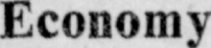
Economy
